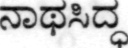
ನಾಥಸಿದ್ದ
